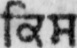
ਕਿਸ
